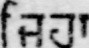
ਜਿਹਾ
